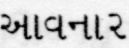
આવનાર
